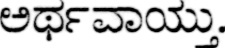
ಅರ್ಥವಾಯ್ತು.
